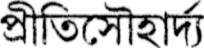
প্রীতিসৌহার্দ্য
